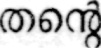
തന്റെ
